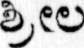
ಶ್ರೀಲ
